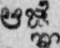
ಆಜ್ಞೆ
